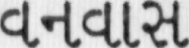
વનવાસ
